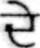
ਦੇ
